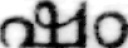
ഷം
